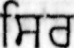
ਸਿਰ
